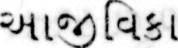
આજીવિકા
